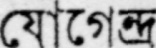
যোগেন্দ্র
